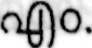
എം.
